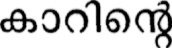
കാറിന്റെ
